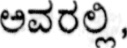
ಅವರಲ್ಲಿ,
